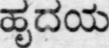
ಹೃದಯ
